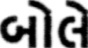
બોલે
